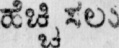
ಹೆಚ್ಚಿಸಲು
